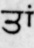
ਤਾਂ
